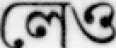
লেও
